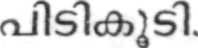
പിടികൂടി.
